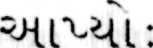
આપ્યોઃ
